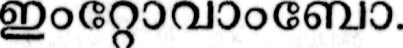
ഇംറ്റോവാംബോ.
